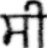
ਸੀ
